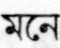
মনে
